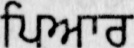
ਪਿਆਰ
